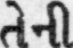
તેની
